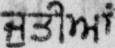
ਜੁਤੀਆਂ
